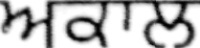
ਅਕਾਲ
